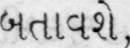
બતાવશે,
